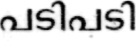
പടിപടി
